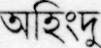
অহিংদু
